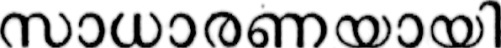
സാധാരണയായി
